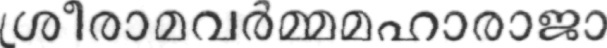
ശ്രീരാമവര്‍മ്മമഹാരാജാ
